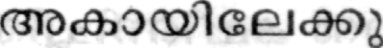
അകായിലേക്കു
